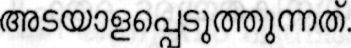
അടയാളപ്പെടുത്തുന്നത്.
